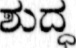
ಶುದ್ಧ
